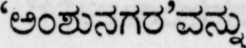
‘ಅಂಶುನಗರ’ವನ್ನು
